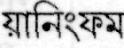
য়ানিংফম
